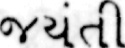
જયંતી
